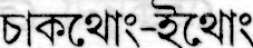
চাকথোং-ইথোং
